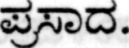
ಪ್ರಸಾದ.
